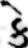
કે
